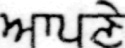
ਆਪਣੇ
